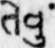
તેવું
